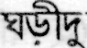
ঘড়ীদু
